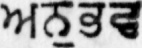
ਅਨੁਭਵ
